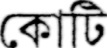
কোটি
